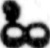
ಹಿ
